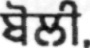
ਬੋਲੀ,
